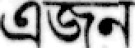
এজন
